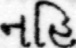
નહિ
